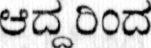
ಆದ್ದರಿಂದ
